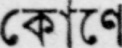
কোণে
